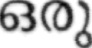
ഒരു
